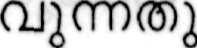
വുന്നതു
